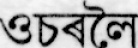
ওচৰলৈ
